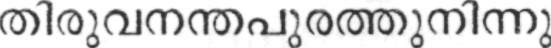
തിരുവനന്തപുരത്തുനിന്നു
